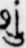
શું
